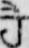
ਹੈ
